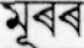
মূৰৰ
